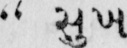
“સુખ
